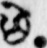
છે.
